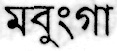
মবুংগা
